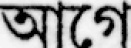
আগে
